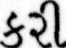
કરી
